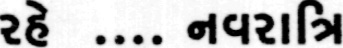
રહે..............નવરાત્રિ
